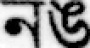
নঙ
